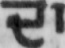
ਦਾ
